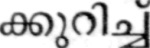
ക്കുറിച്ച്
